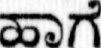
ಹಾಗೆ
